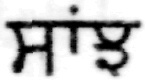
ਸਾਂਝ
